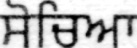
ਸੋਚਿਆ
